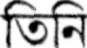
তিনি
